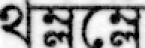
থম্লম্লে
